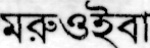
মরুওইবা
